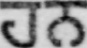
ਹਨ
